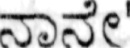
ನಾನೇ
